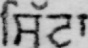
ਸਿੱਟਾ
